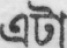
এটা
